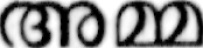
അമ്മ
